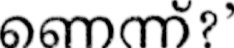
ണെന്ന്?’
